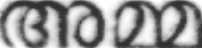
അമ്മ
